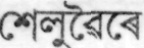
শেলুৱৈৰে
